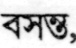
বসন্ত,
